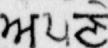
ਆਪਣੇ
